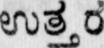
ಉತ್ತರ
